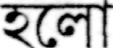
হলো
